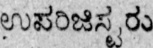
ಉಪರಿಜಿಸ್ಟರು
